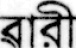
ৱারী
